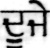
ਦੂਜੇ
